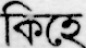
কিহে
